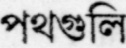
পথগুলি
